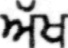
ਅੱਖ
